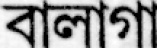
বালাগা
